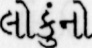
લોકુંનો
